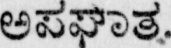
ಅಪಘಾತ.
